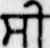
ਸੀ
